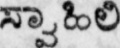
ಸ್ವಾಹಿಲಿ
